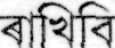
ৰাখিবি
